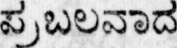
ಪ್ರಬಲವಾದ
